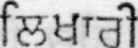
ਲਿਖਾਰੀ
